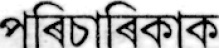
পৰিচাৰিকাক
